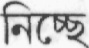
নিচ্ছে
